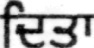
ਦਿਤਾ
